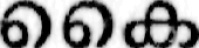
കൈ
